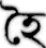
হৈ
